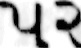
પર
